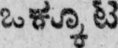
ಒಕ್ಕೂಟ
